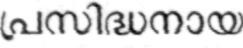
പ്രസിദ്ധനായ
